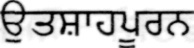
ਉਤਸ਼ਾਹਪੂਰਨ
